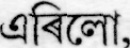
এৰিলো,
